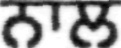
ਨਾਲ
